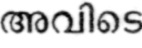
അവിടെ
